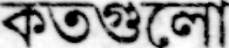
কতগুলো
